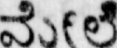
ಮೇಲೆ
